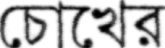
চোখের
